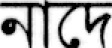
নাদে
